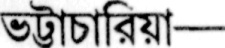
ভট্টাচারিয়া-
